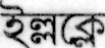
ইল্লক্লে
